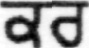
ਕਰ
